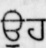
ਉਹ
